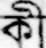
কী
